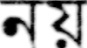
নয়
